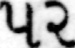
પર
